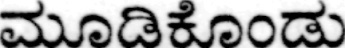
ಮೂಡಿಕೊಂಡು
